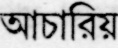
আচারিয়
